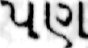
પણ
